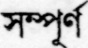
সম্পূর্ণ
